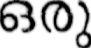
ഒരു
